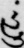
હું
